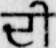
ਦੀ
